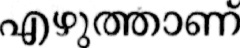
എഴുത്താണ്
